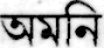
অমনি
